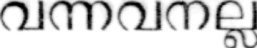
വന്നവനല്ല
